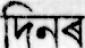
দিনৰ
